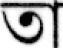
তা
